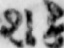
શકે
